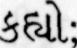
કહ્યો;
